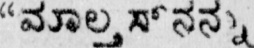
“ಮಾಲ್ತಸ್ನ ನನ್ನು
